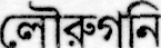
লৌরুগনি
